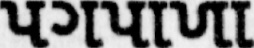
પગપાખા
